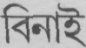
বিনাই
